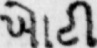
ખોટી
